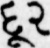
દૂર
